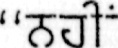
''ਨਹੀਂ
